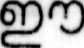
ഈ
